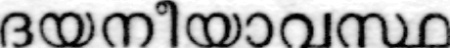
ദയനീയാവസ്ഥ
